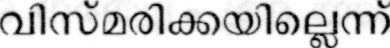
വിസ്മരിക്കയില്ലെന്ന്
